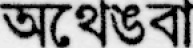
অথেঙবা
